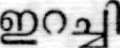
ഇറച്ചി
